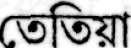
তেতিয়া
